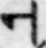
ન
